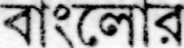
বাংলোর
